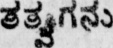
ತತ್ವಗನು
